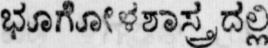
ಭೂಗೋಳಶಾಸ್ತ್ರದಲ್ಲಿ
